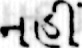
નહીં
